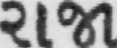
રાજા
